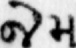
જેમ
